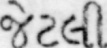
જેટલી
